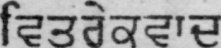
ਵਿਤਰੇਕਵਾਦ
